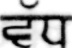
ਵੱਧ
